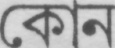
কোন
